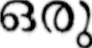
ഒരു
